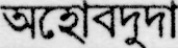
অহোবদুদা
